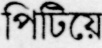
পিটিয়ে
